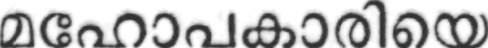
മഹോപകാരിയെ
